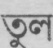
তুল
